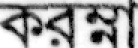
করম্না
